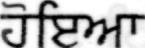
ਹੋਇਆ
